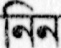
নিন
